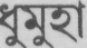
ধুমুহা
